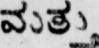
ಮತ್ತು
